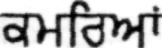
ਕਮਰਿਆਂ
